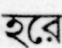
হরে
